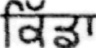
ਕਿੱਡਾ
